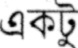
একটু
